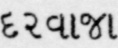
દરવાજા
